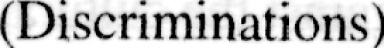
(Discriminations)
